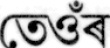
তেওঁৰ
